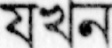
যখন
